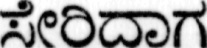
ಸೇರಿದಾಗ
